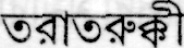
তরাতরুক্কী
